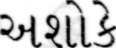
અશોકે
